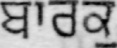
ਬਾਰਕੁ
